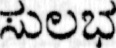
ಸುಲಭ
